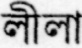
লীলা
